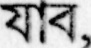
যাব,
